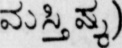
ಮಸ್ತಿಷ್ಕ)
